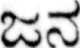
ಜನ
